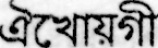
ঐখোয়গী
